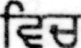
ਵਿਚ
